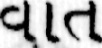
વાત
